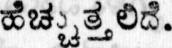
ಹೆಚ್ಚುತ್ತಲಿದೆ.
